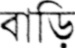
বাড়ি
